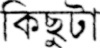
কিছুটা
